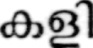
കളി
